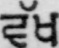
ਵੱਖ
